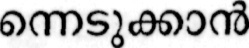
ന്നെടുക്കാന്‍
